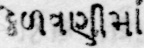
કેળવણીમાં
